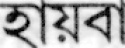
হায়বা
